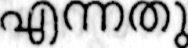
എന്നതു
